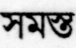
সমস্ত
